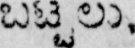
ಬಟ್ಟಲು,
